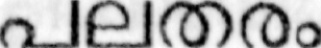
പലതരം
